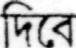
দিবে
